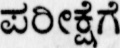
ಪರೀಕ್ಷೆಗೆ
